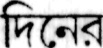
দিনের
